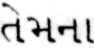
તેમના
